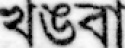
খঙবা
